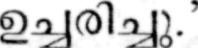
ഉച്ചരിച്ചു.'
